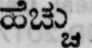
ಹೆಚ್ಚು
